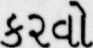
કરવો
